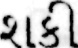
શકી
